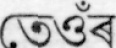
তেওঁৰ
